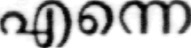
എന്നെ
